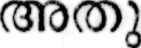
അതു
